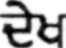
ਦੇਖ
